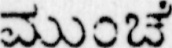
ಮುಂಚೆ
